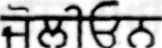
ਜੋਲੀਓਨ
